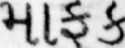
માફક
